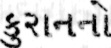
કુરાનનો
